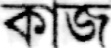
কাজ
